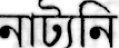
নাট্যনি
